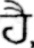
ਹੈ,
